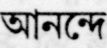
আনন্দে
